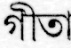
গীতা
